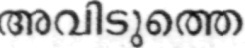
അവിടുത്തെ
